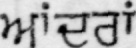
ਆਂਦਰਾਂ
